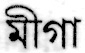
মীগা
